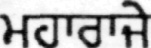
ਮਹਾਰਾਜੇ
